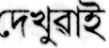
দেখুৱাই
